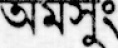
অমসুং
